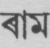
ৰাম
